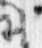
મેં
